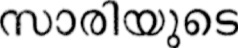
സാരിയുടെ
